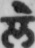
ਲੈ
